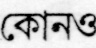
কোনও
